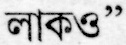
লাকও”
